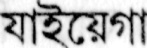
যাইয়েগা
